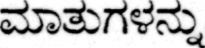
ಮಾತುಗಳನ್ನು
